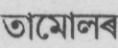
তামোলৰ
